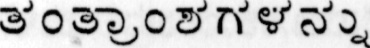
ತಂತ್ರಾಂಶಗಳನ್ನು
